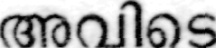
അവിടെ
